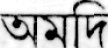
অমদি
